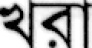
খরা
